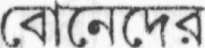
বোনেদের
